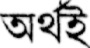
অর্থই
